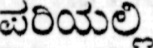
ಪರಿಯಲ್ಲಿ
